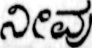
ನೀವು
